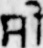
ਸੀ
